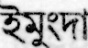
ইমুংদা
